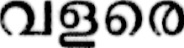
വളരെ
